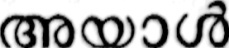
അയാള്‍
